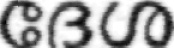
ദേശ
